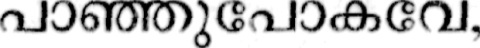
പാഞ്ഞുപോകവേ,
